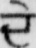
ਦੇ
